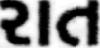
રાત
